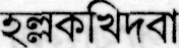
হল্লকখিদবা
